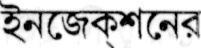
ইনজেক্‌শনের
